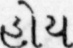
હોય
